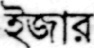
ইজার
